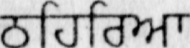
ਠਹਿਰਿਆ
